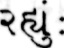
રહ્યું:
